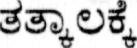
ತತ್ಕಾಲಕ್ಕೆ
